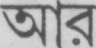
আর
